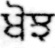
ਬੋਝ
